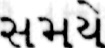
સમયે
